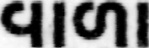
વાળા
